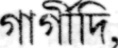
গার্গীদি,
